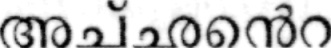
അച്ഛന്റെ
